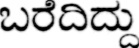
ಬರೆದಿದ್ದು
